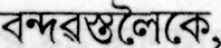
বন্দৱস্তলৈকে,
